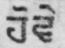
ਹੋਵੇ
